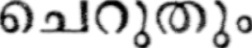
ചെറുതും
